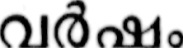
വര്‍ഷം
